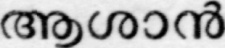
ആശാന്‍
